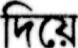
দিয়ে
